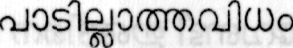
പാടില്ലാത്തവിധം
